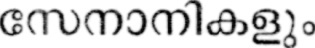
സേനാനികളും
